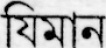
যিমান
